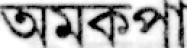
অমকপা
